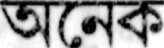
অনেক
